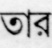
তার
